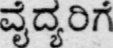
ವೈದ್ಯರಿಗೆ
